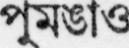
পুমঙাও
